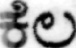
ಕೆಲ
